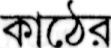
কাঠের
